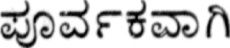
ಪೂರ್ವಕವಾಗಿ
